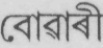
বোৱাৰী
